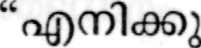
"എനിക്കു
